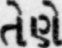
તેણે
